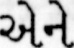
એને
